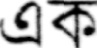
এক
